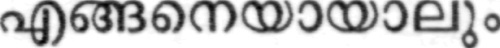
എങ്ങനെയായാലും
